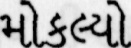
મોકલ્યો
